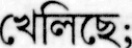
খেলিছে;
